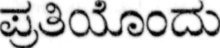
ಪ್ರತಿಯೊಂದು
